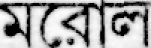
মরোল
